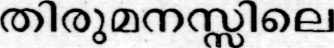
തിരുമനസ്സിലെ
